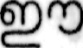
ഈ
